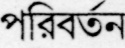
পরিবর্তন
